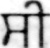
ਸੀ
